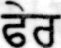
ਫੇਰ
